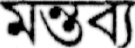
মন্তব্য
